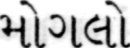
મોગલો
